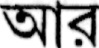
আর
